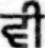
ਵੀ
